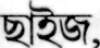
ছাইজ,
